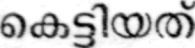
കെട്ടിയത്
